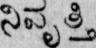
ನಿವೃತ್ತಿ
